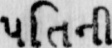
પતિની
